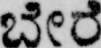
ಬೇರೆ
